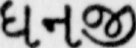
ધનજી
